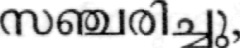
സഞ്ചരിച്ചു,
